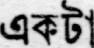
একটা
